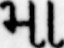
મા
